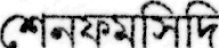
শেনফমসিদি
